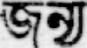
জন্য
